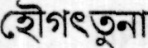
হৌগৎতুনা
